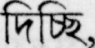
দিচ্ছি,
